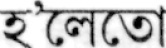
হ'লেতো
